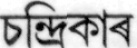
চন্দ্রিকাৰ
